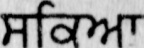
ਸਕਿਆ
